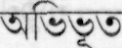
অভিভূত
